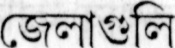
জেলাগুলি
